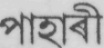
পাহাৰী
